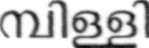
മ്പിള്ളി
